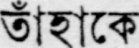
তাঁহাকে
